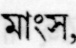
মাংস,
